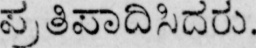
ಪ್ರತಿಪಾದಿಸಿದರು.
